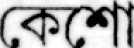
কেশো
